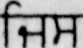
ਜਿਸ
